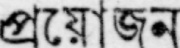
প্রয়োজন
